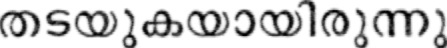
തടയുകയായിരുന്നു
